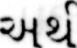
અર્થ
